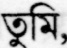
তুমি,
